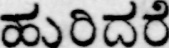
ಹುರಿದರೆ
